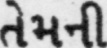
તેમની
